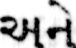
અને
